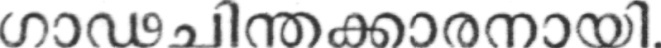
ഗാഢചിന്തക്കാരനായി.
